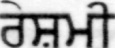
ਰੇਸ਼ਮੀ
